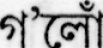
গ'লোঁ
